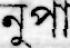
নুপা
